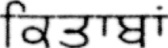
ਕਿਤਾਬਾਂ
